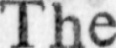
The
